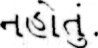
નહોતું.
